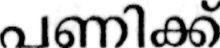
പണിക്ക്
